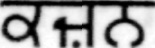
ਕਜ਼ਨ
